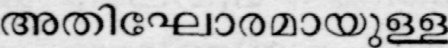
അതിഘോരമായുള്ള
